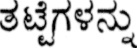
ತಟ್ಟೆಗಳನ್ನು
